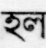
হল
